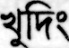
খুদিং
